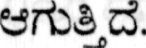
ಆಗುತ್ತಿದೆ.
